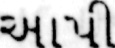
આપી
